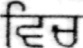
ਵਿਚ
